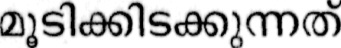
മൂടിക്കിടക്കുന്നത്
